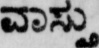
ವಾಸ್ತು
